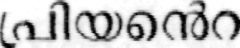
പ്രിയന്റെ
